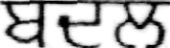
ਬਦਲ
